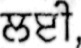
ਲਈ,
